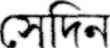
সেদিন
